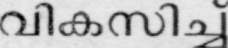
വികസിച്ച്
